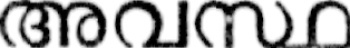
അവസ്ഥ
